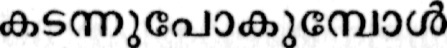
കടന്നുപോകുമ്പോള്‍
